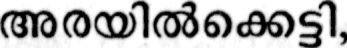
അരയില്‍ക്കെട്ടി,
